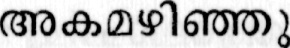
അകമഴിഞ്ഞു
